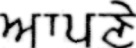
ਆਪਣੇ
